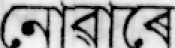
নোৱাৰে
